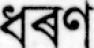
ধৰণ
